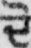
ਦੋ
